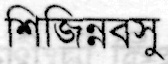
শিজিন্নবসু
